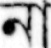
না
